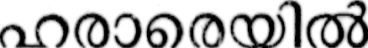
ഹരാരെയില്‍
